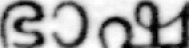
ഭാഷ
